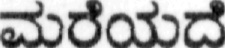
ಮರೆಯದೆ
